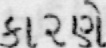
કારણે
